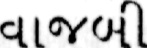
વાજબી
